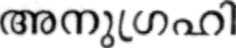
അനുഗ്രഹി
